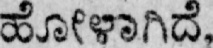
ಹೋಳಾಗಿದೆ.
